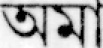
অমা
